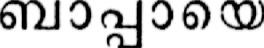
ബാപ്പായെ
